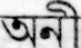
অনী
